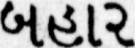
બહાર
